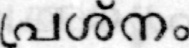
പ്രശ്നം
